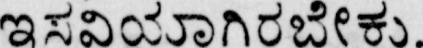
ಇಸವಿಯಾಗಿರಬೇಕು.
